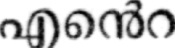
എന്റെ
